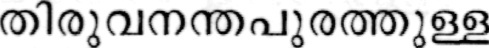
തിരുവനന്തപുരത്തുള്ള
